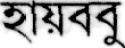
হায়ববু
